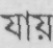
যায়
